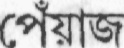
পেঁয়াজ
